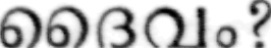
ദൈവം?
